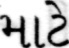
માટે
